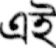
এই
